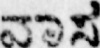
ವಾಸ
